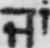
ਜਾਂ
